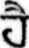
ਹੈ
